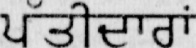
ਪੱਤੀਦਾਰਾਂ
